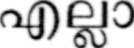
എല്ലാ
